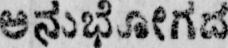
ಅನುಭೋಗದ
